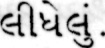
લીધેલું.
